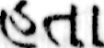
હતા
